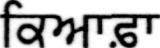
ਕਿਆਫ਼ਾ
